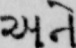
અને
